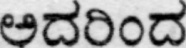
ಅದರಿಂದ
